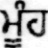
ਮੂੰਹ
